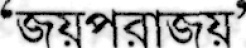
‘জয়পরাজয়’
